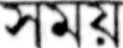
সময়
